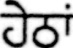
ਹੇਠਾਂ
